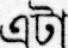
এটা
